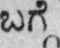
ಬಗ್ಗೆ
